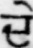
ਦੇ
